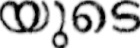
യുടെ
